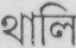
থালি
